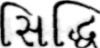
સિદ્ધિ
